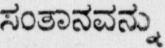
ಸಂತಾನವನ್ನು
